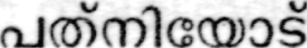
പത്നിയോട്
